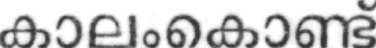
കാലംകൊണ്ട്
